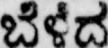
ಬೆಳೆದ
